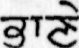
ਭਾਣੇ
